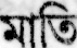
মাতি
